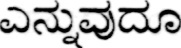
ಎನ್ನುವುದೂ
